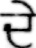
ਦੇ
